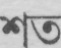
শত
